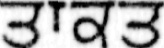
ਤਾਕਤ
